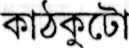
কাঠকুটো
